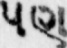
પણ
